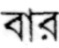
বার
